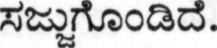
ಸಜ್ಜುಗೊಂಡಿದೆ.
